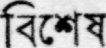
বিশেষ
